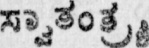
ಸ್ವಾತಂತ್ರ್ಯ
